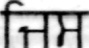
ਜਿਸ
